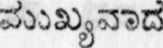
ಮುಖ್ಯವಾದ
